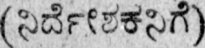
(ನಿರ್ದೇಶಕನಿಗೆ)
